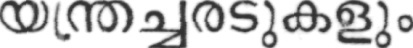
യന്ത്രച്ചരടുകളും
